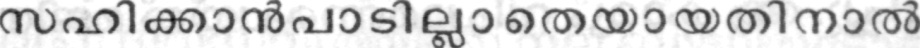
സഹിക്കാന്‍പാടില്ലാതെയായതിനാല്‍
